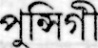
পুন্সিগী
